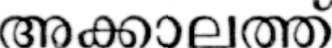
അക്കാലത്ത്
